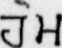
ਹੇਮ
